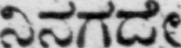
ನಿನಗದೇ
